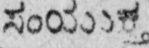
ಸಂಯುಕ್ತ
